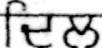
ਦਿਲ
